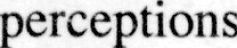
perceptions
